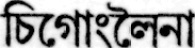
চিগোংলৈনা
